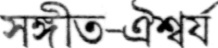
সঙ্গীত-ঐশ্বর্য
